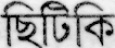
ছিটিকি
